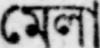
মেলা
